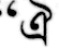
“ঐ
